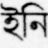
ইনি
